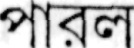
পারল
